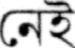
নেই
